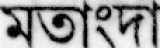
মতাংদা
